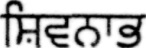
ਸ਼ਿਵਨਾਭ
